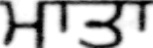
ਮਾਤਾ
